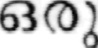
ഒരു
